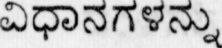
ವಿಧಾನಗಳನ್ನು
